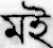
মই
